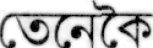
তেনেকৈ
